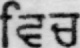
ਵਿਚ
